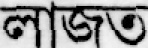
লাজত
